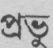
প্ৰভু
